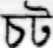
চট
